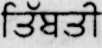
ਤਿੱਬਤੀ
